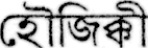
হৌজিক্কী
